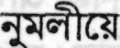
নুমলীয়ে
